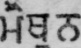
ਮੈਥੁਨ
